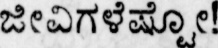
ಜೀವಿಗಳೆಷ್ಟೋ!
